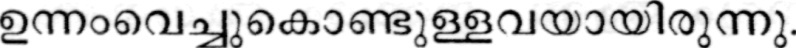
ഉന്നംവെച്ചുകൊണ്ടുള്ളവയായിരുന്നു.
